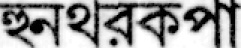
হুনথরকপা
